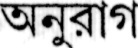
অনুরাগ
